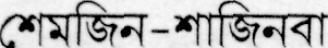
শেমজিন-শাজিনবা
